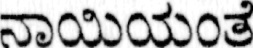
ನಾಯಿಯಂತೆ
